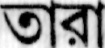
তারা
